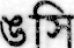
ঙসি
